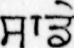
ਸਾਡੇ
